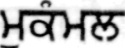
ਮੁਕੰਮਲ
